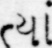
ત્યાં
